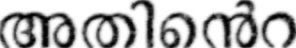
അതിന്റെ
